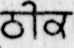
ਠੀਕ
